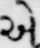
આ
